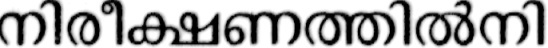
നിരീക്ഷണത്തില്‍നി
